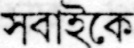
সবাইকে
